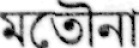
মতৌনা
